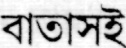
বাতাসই
